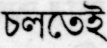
চলতেই
